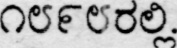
೧೮೯೮ರಲ್ಲಿ.
